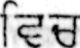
ਵਿਚ
